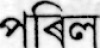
পৰিল
